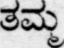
ತಮ್ಮ
